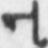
ન
